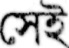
সেই
